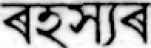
ৰহস্যৰ
